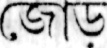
জোড়
